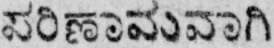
ಪರಿಣಾಮವಾಗಿ
